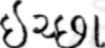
ઈચ્છા
